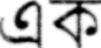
এক
